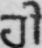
ਹੀ
